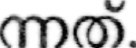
ന്നത്.
